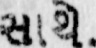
સાથે.
